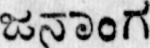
ಜನಾಂಗ
